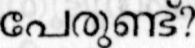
പേരുണ്ട്?
